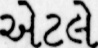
એટલે
